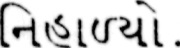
નિહાળ્યો.
